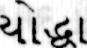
યોદ્ધા
